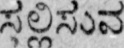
ಸಲ್ಲಿಸುವ
